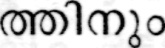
ത്തിനും
